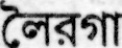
লৈরগা
